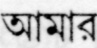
আমার
